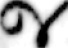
જ
